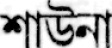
শাউনা
